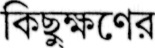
কিছুক্ষণের
